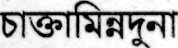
চাক্তামিন্নদুনা
